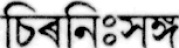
চিৰনিঃসঙ্গ
